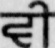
ਵੀ
